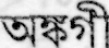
অঙ্কগী
